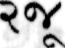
રજૂ
